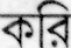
করি
